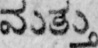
ಮತ್ತು
